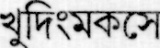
খুদিংমকসে
